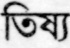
তিষ্য
